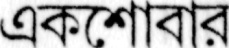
একশোবার
